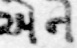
એને
